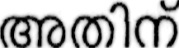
അതിന്
